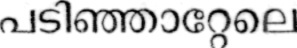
പടിഞ്ഞാറ്റേലെ
